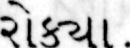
રોક્યા.
